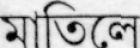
মাতিলে
